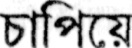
চাপিয়ে
